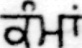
ਕੰਮਾਂ
